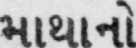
માથાનો
